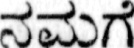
ನಮಗೆ
